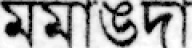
মমাঙদা
